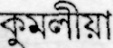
কুমলীয়া
